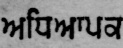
ਅਧਿਆਪਕ
